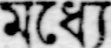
মধ্যে
